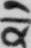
ਕੇ
